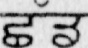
ਛੱਡ
